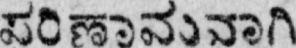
ಪರಿಣಾಮವಾಗಿ
